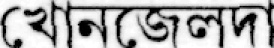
খোনজেলদা
